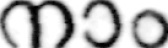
നാം
